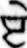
ਏ
